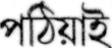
পঠিয়াই
